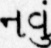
નવું
